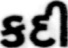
કદી
